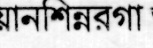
য়ানশিন্নরগা
